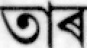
তাৰ
